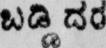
ಬಡ್ಡಿದರ
